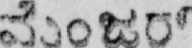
ಮೆಂಜರ್
